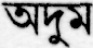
অদুম
